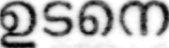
ഉടനെ
